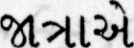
જાત્રાએ
